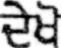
ਦੇਖੋ
